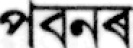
পবনৰ
